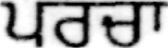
ਪਰਚਾ
